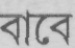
বাবে
